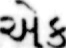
એક
